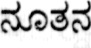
ನೂತನ
